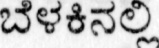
ಬೆಳಕಿನಲ್ಲಿ
